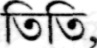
তিতি,
